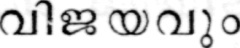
വിജയവും
